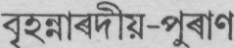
বৃহন্নাৰদীয়-পুৰাণ,
